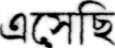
এসেছি
